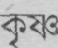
কৃষ্ণ
